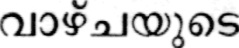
വാഴ്ചയുടെ
